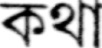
কথা
